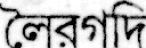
লৈরগদি
